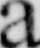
a
